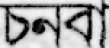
চনবা
